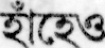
হাঁহেও
